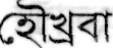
হৌখ্রবা
